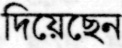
দিয়েছেন
